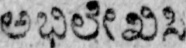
ಅಭಿಲೇಖಿಸಿ
